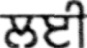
ਲਈ
